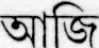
আজি
